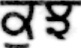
ਕੁਝ
